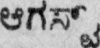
ಆಗಸ್ಟ್
